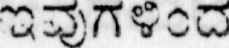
ಇವುಗಳಿಂದ
